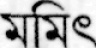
মমিৎ
